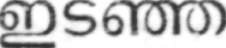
ഇടഞ്ഞ
